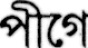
পীগে
